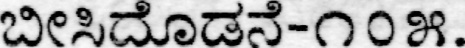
ಬೀಸಿದೊಡನೆ-೧೦೫-
